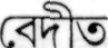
বেদীত
